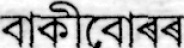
বাকীবোৰৰ
